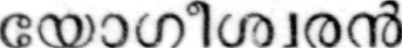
യോഗീശ്വരന്‍
